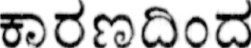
ಕಾರಣದಿಂದ
